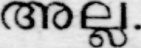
അല്ല.
